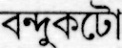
বন্দুকটো
